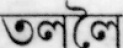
তললৈ
